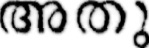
അതു
